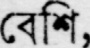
বেশি,
